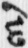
દે
